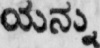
ಯನ್ನು
